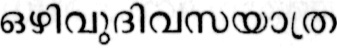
ഒഴിവുദിവസയാത്ര
